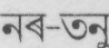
নৰ-তনু
